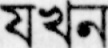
যখন
